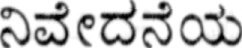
ನಿವೇದನೆಯ
